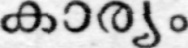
കാര്യം
